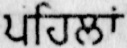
ਪਹਿਲਾਂ
